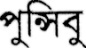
পুন্সিবু
